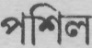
পশিল
